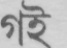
গই
